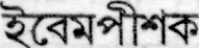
ইবেমপীশক
